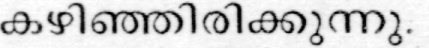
കഴിഞ്ഞിരിക്കുന്നു.
